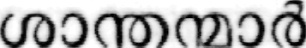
ശാന്തന്മാര്‍
